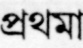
প্রথমা
